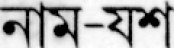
নাম-যশ
